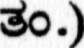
ತಂ .)
